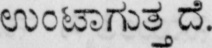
ಉಂಟಾಗುತ್ತದೆ.
